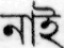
নাই
